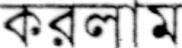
করলাম
